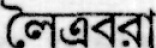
লৈত্রবরা
